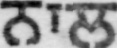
ਨਾਲ
